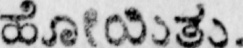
ಹೋಯಿತು.
